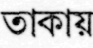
তাকায়
